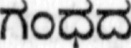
ಗಂಧದ
